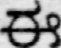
ಈ
